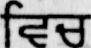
ਵਿਚ
